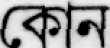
কোন
